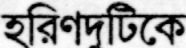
হরিণদুটিকে
